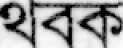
থবক
